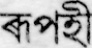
ৰূপহী
